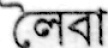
লৈবা
